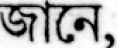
জানে,
